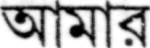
আমার
